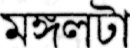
মঙ্গলটা
